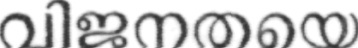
വിജനതയെ
